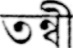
তন্বী
